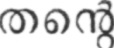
തന്റെ
